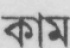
কাম
